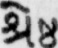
શ્રેષ્ઠ
